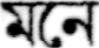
মনে
